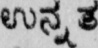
ಉನ್ನತ
